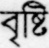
বৃষ্টি
